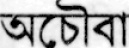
অচৌবা
